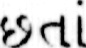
છતાં
